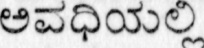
ಅವಧಿಯಲ್ಲಿ
